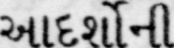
આદર્શોની
